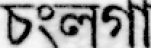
চংলগা
